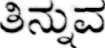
ತಿನ್ನುವ
